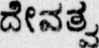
ದೇವತ್ವ
